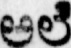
ಅಲೆ
